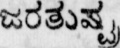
ಜರತುಷ್ಟ್ರ
